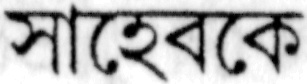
সাহেবকে
